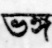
ভঙ্গ
